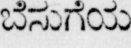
ಬೆಸುಗೆಯ
